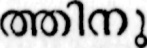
ത്തിനു
